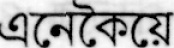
এনেকৈয়ে
